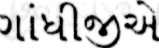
ગાંધીજીએ
